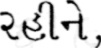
રહીને,
